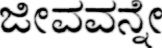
ಜೀವವನ್ನೇ
